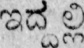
ಇದ್ದಲ್ಲಿ
